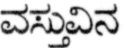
ವಸ್ತುವಿನ
